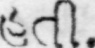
હતી.
